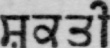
ਸ਼ਕਤੀ
